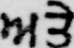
ਅਤੇ
